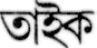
তাইক
